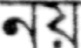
নয়
